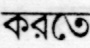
করতে
